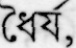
ধৈর্য,
